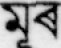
মূৰ
